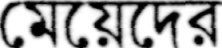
মেয়েদের
